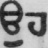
ਉਹ
